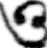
ও
